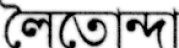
লৈতোন্দা
